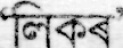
'লিকৰ'
